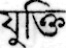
যুক্তি
